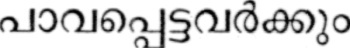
പാവപ്പെട്ടവര്‍ക്കും
